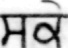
ਸਕੇ
